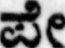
ಪೇ
